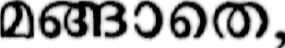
മങ്ങാതെ,
